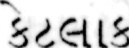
કેટલાક
